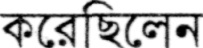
করেছিলেন
